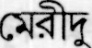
মেরীদু
